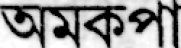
অমকপা
